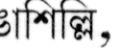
ঙাশিল্লি,
